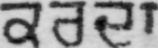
ਕਰਦਾ
